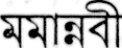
মমান্নবী
